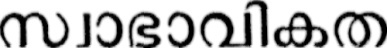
സ്വാഭാവികത
